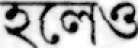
হলেও
